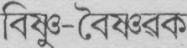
বিষ্ণু-বৈষ্ণৱক
